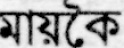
মায়কৈ
